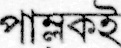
পাম্লকই
